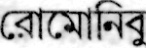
রোমোনিবু
